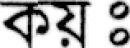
কয়ঃ
